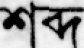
শব্দ
